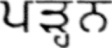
ਪੜ੍ਹਨ
